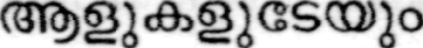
ആളുകളുടേയും
